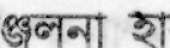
লৈশেম্বনা
